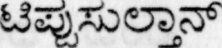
ಟಿಪ್ಪುಸುಲ್ತಾನ್
